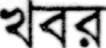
খবর
